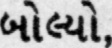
બોલ્યો,
